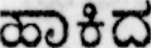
ಹಾಕಿದ
